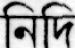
নিদি
